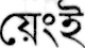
য়েংই
